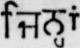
ਜਿਨ੍ਹਾਂ
